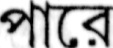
পারে
